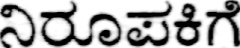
ನಿರೂಪಕಿಗೆ
